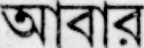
আবার
